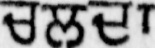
ਚਲਦਾ
